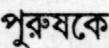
পুরুষকে
